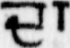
ਦਾ
